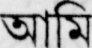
আমি
